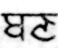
ਬਣ
